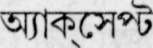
অ্যাক্‌সেপ্ট
